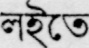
লইতে
